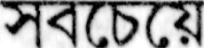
সবচেয়ে
